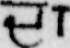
ਦਾ
